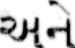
અને
